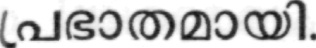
പ്രഭാതമായി.
